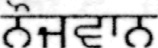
ਨੌਜਵਾਨ
